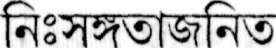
নিঃসঙ্গতাজনিত
